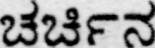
ಚರ್ಚಿನ
